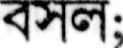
বসল;
